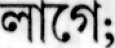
লাগে;
